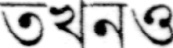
তখনও
